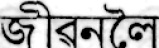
জীৱনলৈ
